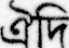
ঐদি
